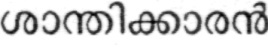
ശാന്തിക്കാരന്‍
